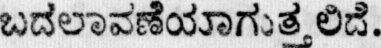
ಬದಲಾವಣೆಯಾಗುತ್ತಲಿದೆ.
